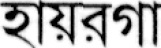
হায়রগা
